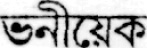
ভনীয়েক
